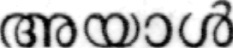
അയാള്‍
